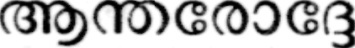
ആന്തരോദ്ദേ
